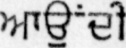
ਆਉਂਦੀ
